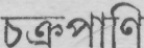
চক্ৰপাণি
